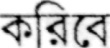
করিবে
